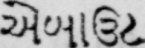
એબાઉટ
